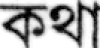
কথা
